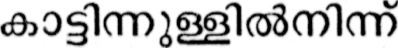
കാട്ടിന്നുള്ളില്‍നിന്ന്
